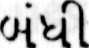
બંધી
